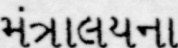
મંત્રાલયના
